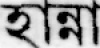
হান্না
